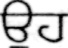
ਉਹ
